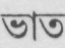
ভাত
